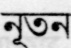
নূতন
